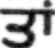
ਤਾਂ
